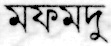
মফমদু
